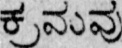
ಕ್ರಮವು
